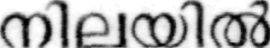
നിലയില്‍
